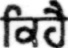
ਕਿਹੈ
